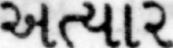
અત્યાર
